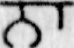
ਨਾ
